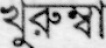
খুরুম্বা
